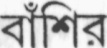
বাঁশির
